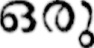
ഒരു
